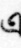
এ
